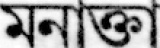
মনাক্তা
